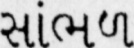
સાંભળ
